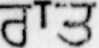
ਰਾਤ
